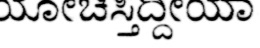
ಯೋಚಿಸ್ತಿದ್ದೀಯಾ
